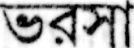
ভরসা
